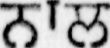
ਨਾਲ
